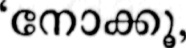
‘നോക്കൂ,
